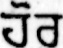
ਹੋਰ
